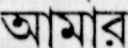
আমার
